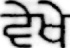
ਵੇਖੇ
